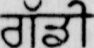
ਗੱਡੀ
